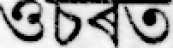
ওচৰত
